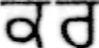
ਕਰ
